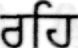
ਰਹਿ
